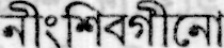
নীংশিংবগীনো
